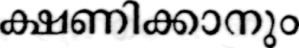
ക്ഷണിക്കാനും
